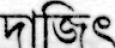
দাজিৎ
